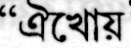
“ঐখোয়
